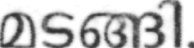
മടങ്ങി.
